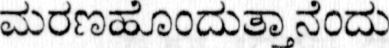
ಮರಣಹೊಂದುತ್ತಾನೆಂದು
